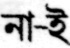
না-ই
